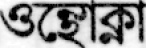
ওন্থোক্না
